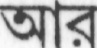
আর
